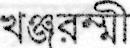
খঞ্জরম্মী
